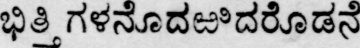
ಭಿತ್ತಿಗಳನೊದಱಿದರೊಡನೆ
